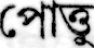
পোত্তু
